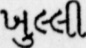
ખુલ્લી
